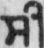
ਸੀ
